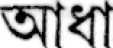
আধা
